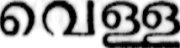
വെള്ള
